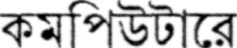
কমপিউটারে
